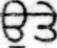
ਉਤੇ
